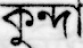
কুন্দা
